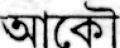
আকৌ
